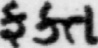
ફક્ત
